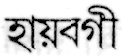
হায়বগী
